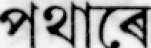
পথাৰে
